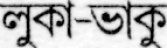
লুকা-ভাকু
